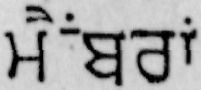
ਮੈਂਬਰਾਂ
